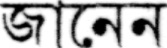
জানেন
